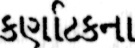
કર્ણાટકના
